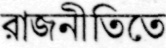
রাজনীতিতে
